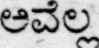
ಅವೆಲ್ಲ
